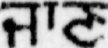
ਜਾਣ
